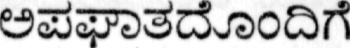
ಅಪಘಾತದೊಂದಿಗೆ
